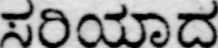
ಸರಿಯಾದ
